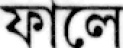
ফালে
